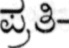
ಪ್ರತಿ-
